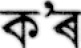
ক'ৰ
